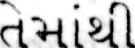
તેમાંથી
